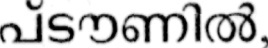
പ്ടൌണില്‍,
